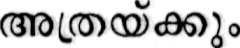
അത്രയ്ക്കും
